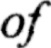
of
